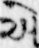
એ
